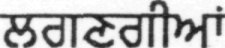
ਲਗਣਗੀਆਂ
